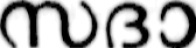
സദാ
